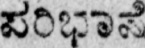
ಪರಿಭಾಷೆ
